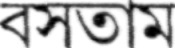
বসতাম
